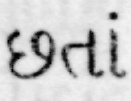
છતાં
